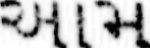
આમ
